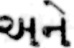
અને
